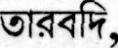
তারবদি,
